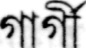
গার্গী
